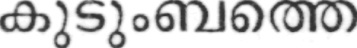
കുടുംബത്തെ
